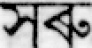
সৰু
